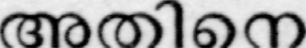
അതിനെ
